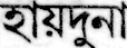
হায়দুনা
